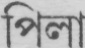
পিলা
